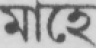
মাহে
